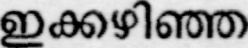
ഇക്കഴിഞ്ഞ
